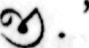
જી.'
